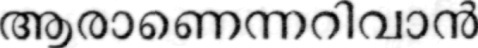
ആരാണെന്നറിവാന്‍
